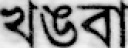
খঙবা
